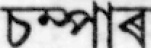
চম্পাৰ
